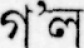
গ'ল
